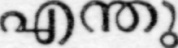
എന്തു
